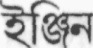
ইঞ্জিন
